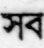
সব
